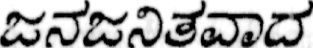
ಜನಜನಿತವಾದ
